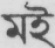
মই
